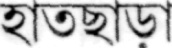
হাতছাড়া
